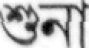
শুনা
